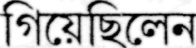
গিয়েছিলেন
